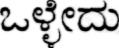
ಒಳ್ಳೇದು
